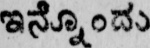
ಇನ್ನೊಂದು
